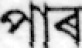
পাৰ
